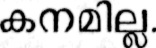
കനമില്ല.
